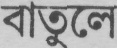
বাতুলে
